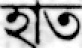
হাত
